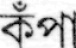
কঁপা
